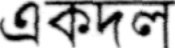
একদল
